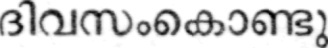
ദിവസംകൊണ്ടു
